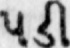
પડી
